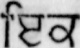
ਇਕ
